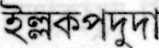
ইল্লকপদুদা
